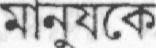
মানুষকে
